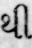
થી
